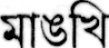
মাঙখি
